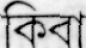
কিবা
